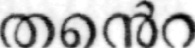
തന്റെ
